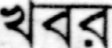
খবর
